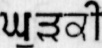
ਘੁੜਕੀ
